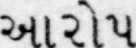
આરોપ
